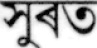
সুৰত
